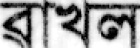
ৱাখল
